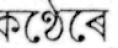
কণ্ঠেৰে
